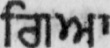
ਗਿਆ
